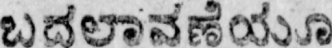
ಬದಲಾವಣೆಯೂ
